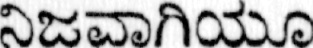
ನಿಜವಾಗಿಯೂ
